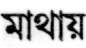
মাথায়
